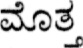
ಮೊತ್ತ
